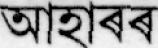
আহাৰৰ
